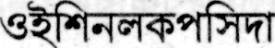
ওইশিনলকপসিদা
